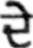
ਦੇ
